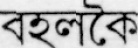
বহলকৈ
